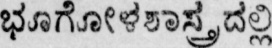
ಭೂಗೋಳಶಾಸ್ತ್ರದಲ್ಲಿ
